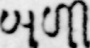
બળી
